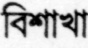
বিশাখা
